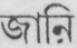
জানি
